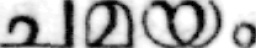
ചമയം
